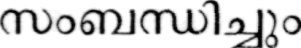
സംബന്ധിച്ചും
